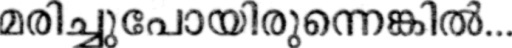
മരിച്ചുപോയിരുന്നെങ്കില്‍...
